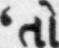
'તો
